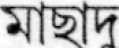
মাছাদু
